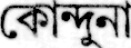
কোন্দুনা
